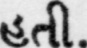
હતી.
